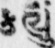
કહ્યું
